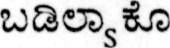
ಬಡಿಲಾಽಕೊ
